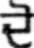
ਦੋ
